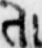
તો
